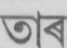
তাৰ
